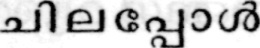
ചിലപ്പോള്‍
